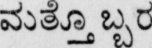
ಮತ್ತೊಬ್ಬರ
